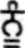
ਨੂੰ
